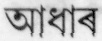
আধাৰ
